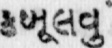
કબૂલવું
